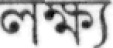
লক্ষ্য
